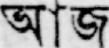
আজ
